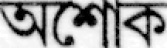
অশোক
